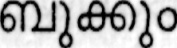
ബുക്കും
